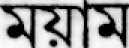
ময়াম
